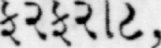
ફરફરાટ,
